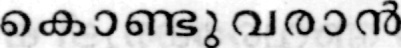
കൊണ്ടുവരാന്‍
